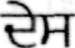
ਦੇਸ
